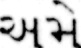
અમે
